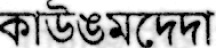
কাউঙমদেদা
